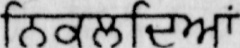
ਨਿਕਲਦਿਆਂ
